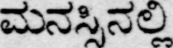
ಮನಸ್ಸಿನಲ್ಲಿ
